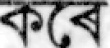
কৰে
